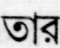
তার
